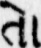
તો
